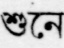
শুনে
